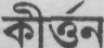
কীৰ্ত্তন
